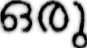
ഒരു
